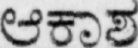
ಆಕಾಶ
